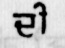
ਦੀ
